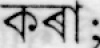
কৰা;
